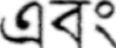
এবং
